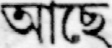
আছে
